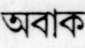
অবাক
